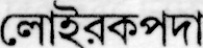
লোইরকপদা
